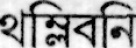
থম্লিবনি
